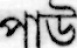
পাউ
